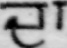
ਦਾ
